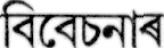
বিবেচনাৰ
